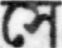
সে
